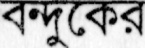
বন্দুকের
